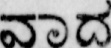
ವಾದ
